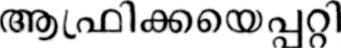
ആഫ്രിക്കയെപ്പറ്റി
